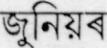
জুনিয়ৰ
